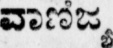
ವಾಣಿಜ್ಯ
